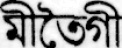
মীতৈগী
